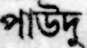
পাউদু
